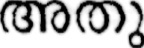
അതു
